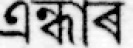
এন্ধাৰ
